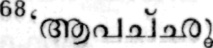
68'ആപച്ഛൂ
